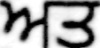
ਅਤ
